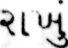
રાખું
